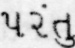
પરંતુ
